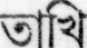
তাখি
